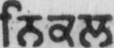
ਨਿਕਲ
